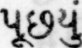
પૂછ્યું
